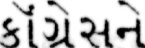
કૉંગ્રેસને
